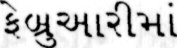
ફેબ્રુઆરીમાં
